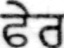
ਫੇਰ
